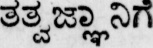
ತತ್ವಜ್ಞಾನಿಗೆ
